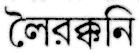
লৈরক্কনি
